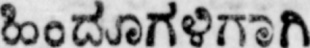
ಹಿಂದೂಗಳಿಗಾಗಿ
